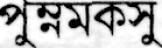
পুম্নমকসু
